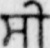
ਸੀ
